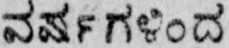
ವರ್ಷಗಳಿಂದ
